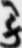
કે
